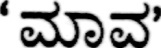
'ಮಾವ'
